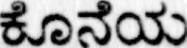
ಕೊನೆಯ
